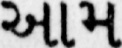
આમ
